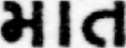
માત
